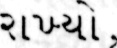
રાખ્યો,
